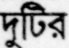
দুটির
